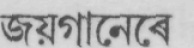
জয়গানেৰে
